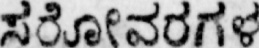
ಸರೋವರಗಳ
